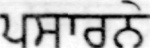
ਪਸਾਰਨੇ
